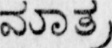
ಮಾತ್ರ
